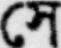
সে
